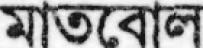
মাতবোল
